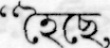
"হৈছে,
